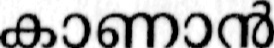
കാണാന്‍
